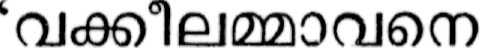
‘വക്കീലമ്മാവനെ
